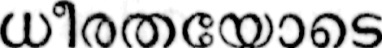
ധീരതയോടെ
